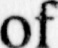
of
